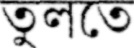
তুলতে
